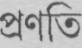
প্ৰণতি
